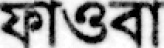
ফাওবা
